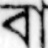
বা
